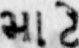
માટે
